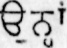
ਉਨ੍ਹਾਂ
